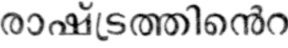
രാഷ്ട്രത്തിന്റെ
